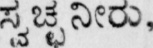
ಸ್ವಚ್ಛನೀರು,
